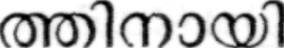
ത്തിനായി
